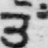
ਤੋਂ
